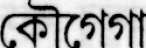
কৌগেগা
